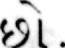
છો.
